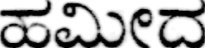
ಹಮೀದ
